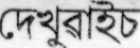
দেখুৱাইচ
